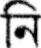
নি
